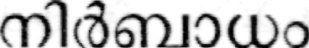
നിര്‍ബാധം
